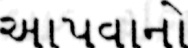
આપવાનો
